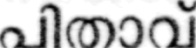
പിതാവ്
